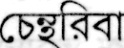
চেন্থরিবা
